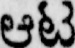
ಆಟ
